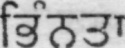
ਭਿੰਨਤਾ
